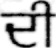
ਦੀ
